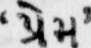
'પ્રેમ'
